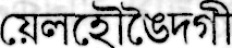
য়েলহৌঙৈদগী
